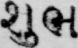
શુભ
